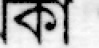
কা
